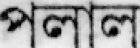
পলাল
